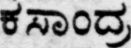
ಕಸಾಂದ್ರ
